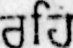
ਰਹਿ
